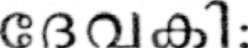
ദേവകി:
